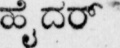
ಹೈದರ್
